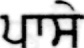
ਪਾਸੇ
